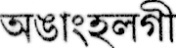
অঙাংহলগী
